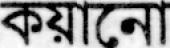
কয়ানো
